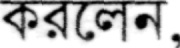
করলেন,
